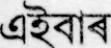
এইবাৰ
